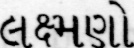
લક્ષ્મણો
